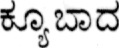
ಕ್ಯೂಬಾದ
